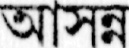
আসন্ন
